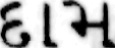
દામ
